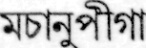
মচানুপীগা
